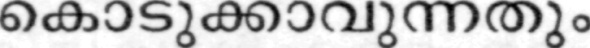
കൊടുക്കാവുന്നതും
